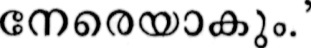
നേരെയാകും.’
